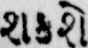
શકશે
